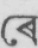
ৰে
